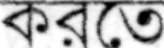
করতে
